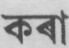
কৰা
